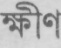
ক্ষীণ
